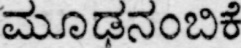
ಮೂಢನಂಬಿಕೆ
